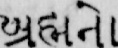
બ્રહ્મનો
